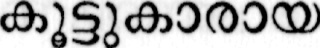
കൂട്ടുകാരായ
